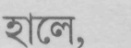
হালে,
